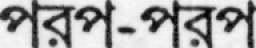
পরপ-পরপ
